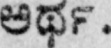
ಅರ್ಥ.
